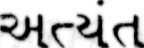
અત્યંત
